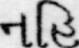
નહિ
